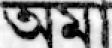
অমা
